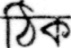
ঠিক
